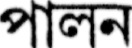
পালন
